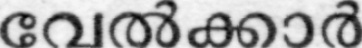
വേല്‍ക്കാര്‍
